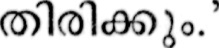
തിരിക്കും.’
